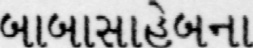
બાબાસાહેબના
